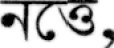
নত্তে,
